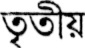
তৃতীয়
